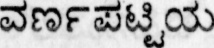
ವರ್ಣಪಟ್ಟಿಯ
